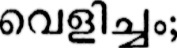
വെളിച്ചം;
